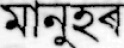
মানুহৰ
